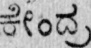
ಕೇಂದ್ರ
